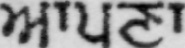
ਆਪਣਾ
